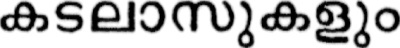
കടലാസുകളും
